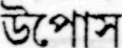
উপোস
